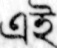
এই
